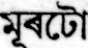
মূৰটো
